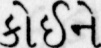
કોઈને
